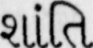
શાંતિ
